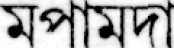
মপামদা
